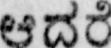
ಆದರೆ
